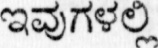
ಇವುಗಳಲ್ಲಿ
